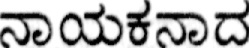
ನಾಯಕನಾದ
